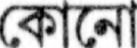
কোনো
